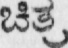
ಚಿತ್ರ
